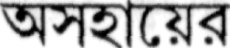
অসহায়ের
